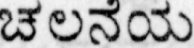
ಚಲನೆಯ
